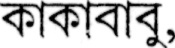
কাকাবাবু,
